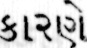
કારણે
